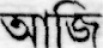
আজি
